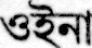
ওইনা
